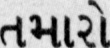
તમારો
